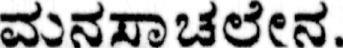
ಮನಸಾಚಲೇನ.
